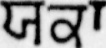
ਯਕਾ
